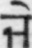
ਜੇ
